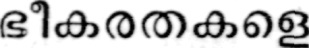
ഭീകരതകളെ
